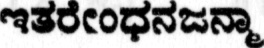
ಇತರೇಂಧನಜನ್ಮಾ
